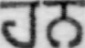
ਹਨ
